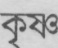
কৃষ্ণ
